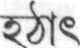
হঠাৎ
